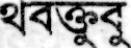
থবক্তুবু
